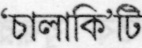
‘চালাকি’টি
